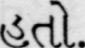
હતો.
